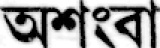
অশংবা
